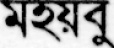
মহয়বু
